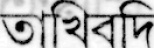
তাখিবদি
